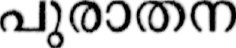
പുരാതന
